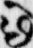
છે
